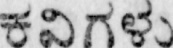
ಕವಿಗಳು
